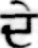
ਦੇ
